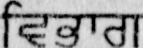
ਵਿਭਾਗ
